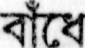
বাঁধে
